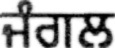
ਜੰਗਲ
